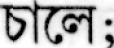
চালে;
